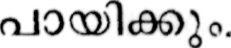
പായിക്കും.
